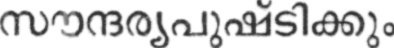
സൗന്ദര്യപുഷ്ടിക്കും
